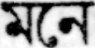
মনে
